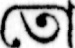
তো
